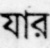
যার
